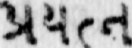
પ્રયત્ન
